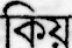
কিয়
